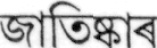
জাতিষ্কাৰ
